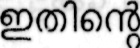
ഇതിന്റെ
